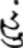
હું
